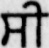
ਸੀ
